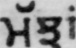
ਮੱਝਾਂ
